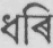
ধৰি
